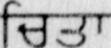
ਚਿਤਾ
